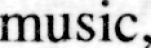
music,
